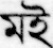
মই
